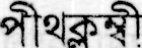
পীথক্লম্বী
